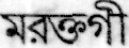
মরক্তগী
